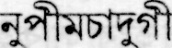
নুপীমচাদুগী
